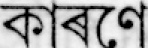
কাৰণে
